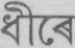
ধীৰে
